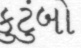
કુટુંબો
